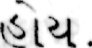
હોય.
